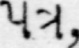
પત્ર,
